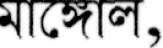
মাঙ্গোল
